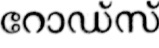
റോഡ്സ്
